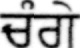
ਚੰਗੇ
